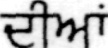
ਦੀਆਂ
